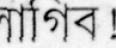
লাগিব!
